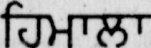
ਹਿਮਾਲਾ
